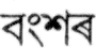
বংশৰ
